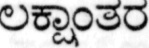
ಲಕ್ಷಾಂತರ
